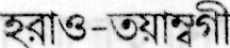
হরাও-তয়াম্বগী
